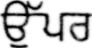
ਉੱਪਰ
